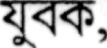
যুবক,
